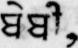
ਬੇਬੀ,
